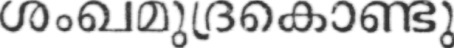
ശംഖമുദ്രകൊണ്ടു
